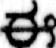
ಈ
